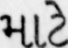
માટે
